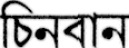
চিনবান
